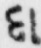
દા
